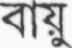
বায়ু
